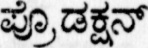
ಪ್ರೊಡಕ್ಷನ್
